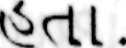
હતા.
